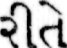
રીતે
